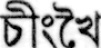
চীংখৈ
